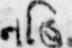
નહિ.
